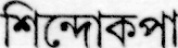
শিন্দোকপা
